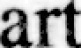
art
